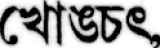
খোঙচৎ,
